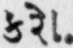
કરો.
